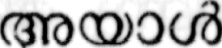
അയാള്‍
